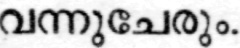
വന്നുചേരും.
